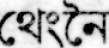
থেংনৈ
